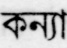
কন্যা
